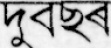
দুবছৰ
